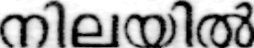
നിലയില്‍
